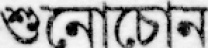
শুনোচোন
